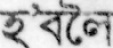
হ'বলৈ
